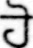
ਹੋ
